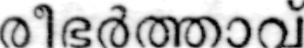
രീഭര്‍ത്താവ്
